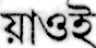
য়াওই
